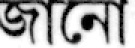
জানো
